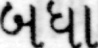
બધા
